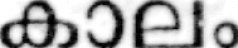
കാലം
